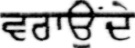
ਵਰਾਉਂਦੇ
